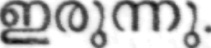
ഇരുന്നു.
